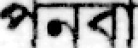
পনবা
